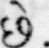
છે.
